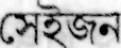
সেইজন
